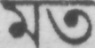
মত
